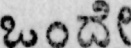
ಒಂದೇ
